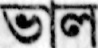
ভাল
